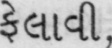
ફેલાવી,
